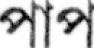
পাপ
